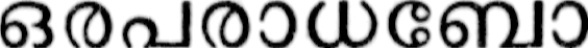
ഒരപരാധബോ
